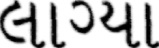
લાગ્યા
